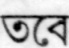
তবে
